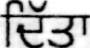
ਦਿੱਤਾ
